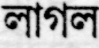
লাগল
